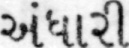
અંધારી
